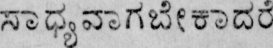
ಸಾಧ್ಯವಾಗಬೇಕಾದರೆ
